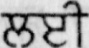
ਲਈ
